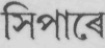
সিপাৰে
